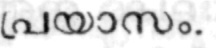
പ്രയാസം.
